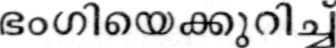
ഭംഗിയെക്കുറിച്ച്
